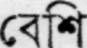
বেশি
